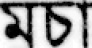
মচা
